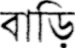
বাড়ি
